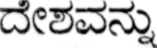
ದೇಶವನ್ನು
